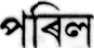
পৰিল
